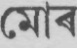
মোৰ
